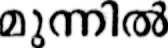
മുന്നില്‍
